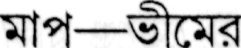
মাপ–ভীমের
